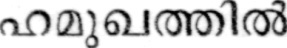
ഹമുഖത്തില്‍
